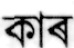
কাৰ
